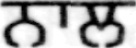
ਨਾਲ
